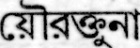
য়ৌরক্তুনা
